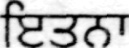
ਇਤਨਾ
